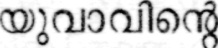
യുവാവിന്റെ
